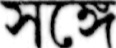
সঙ্গে
